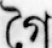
গৈ
